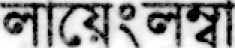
লায়েংলম্বা
